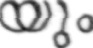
യും
